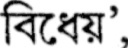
বিধেয়',
